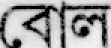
বোল
